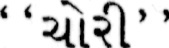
"ચોરી"
